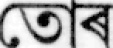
তোৰ
